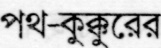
পথ-কুক্কুরের
